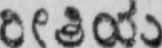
ರೀತಿಯ
